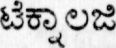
ಟೆಕ್ನಾಲಜಿ
